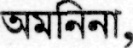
অমনিনা,
